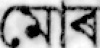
মোৰ
